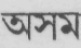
অসম
